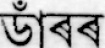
ডাঁৰৰ
